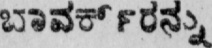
ಬಾವರ್ಕರನ್ನು
